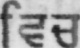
ਵਿਚ
